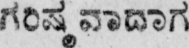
ಗರಿಷ್ಠವಾದಾಗ
